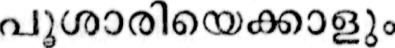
പൂശാരിയെക്കാളും
